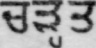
ਚੜ੍ਹਤ
